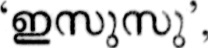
‘ഇസുസു',
